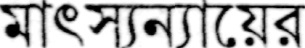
মাত্স্যন্যায়ের
